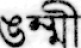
ঙম্মী
